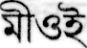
মীওই
